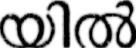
യില്‍
